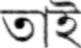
তাই
